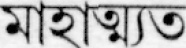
মাহাত্ম্যত
